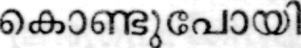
കൊണ്ടുപോയി
